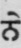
ਨੇ
